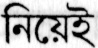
নিয়েই
